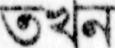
তখন
